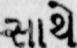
સાથે
